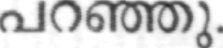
പറഞ്ഞു.
